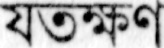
যতক্ষণ
